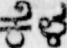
ಕೆಳ
